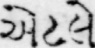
એટલે
